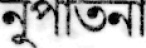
নুপাতনা
